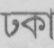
ঢকা
